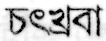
চৎখ্রবা
